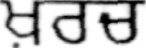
ਖ਼ਰਚ
